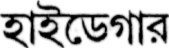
হাইডেগার
